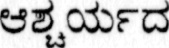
ಆಶ್ಚರ್ಯದ
